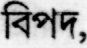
বিপদ,
